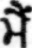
ਮੈਂ
